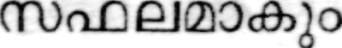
സഫലമാകും
